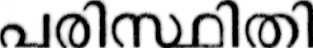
പരിസ്ഥിതി
